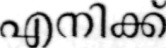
എനിക്ക്
